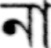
না
